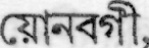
য়োনবগী,
